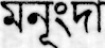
মনূংদা
